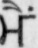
ਮੈਂ
